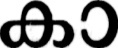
കാ
